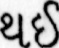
થઈ
